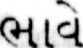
ભાવે
